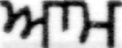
ਆਮ
